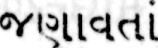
જણાવતાં
